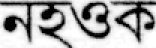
নহওক
